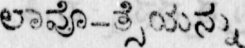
ಲಾವೊ-ತ್ಸೆಯನ್ನು
